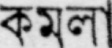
কমলা
